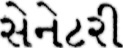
સેનેટરી
